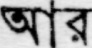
আর
